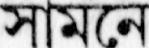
সামনে
